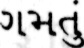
ગમતું
